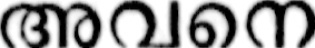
അവനെ
